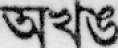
অখঙ
